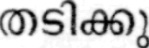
തടിക്കു
